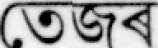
তেজৰ
